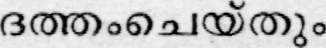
ദത്തംചെയ്തും
